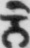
ਨੇ
